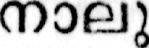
നാലു
